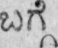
ಬಗ್ಗೆ
